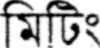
মিটিং
